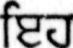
ਇਹ
